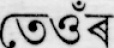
তেওঁৰ
